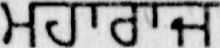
ਮਹਾਰਾਜ
